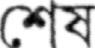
শেষ
